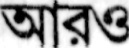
আরও
